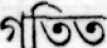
গতিত
